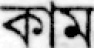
কাম
